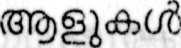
ആളുകള്‍
